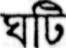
ঘটি
